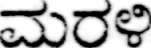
ಮರಳಿ
